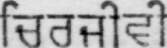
ਚਿਰਜੀਵੀ
